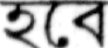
হবে
